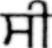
ਸੀ
